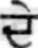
ਦੇ
